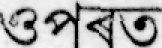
ওপৰত
